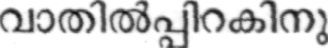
വാതില്‍പ്പിറകിനു
